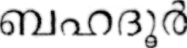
ബഹദൂര്‍
